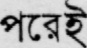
পরেই
